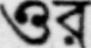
ওর
